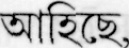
আহিছে,
